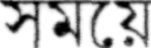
সময়ে
